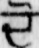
ਦੋ
